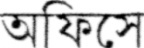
অফিসে
